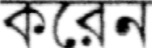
করেন
